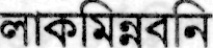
লাকমিন্নবনি
